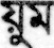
য়ুম
